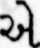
એ
